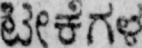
ಟೀಕೆಗಳ
